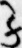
કે
